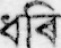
ধৰি
